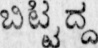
ಬಿಟ್ಟಿದ್ದ
